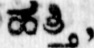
ಹತ್ತಿ,
